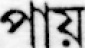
পায়
